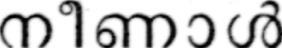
നീണാള്‍
